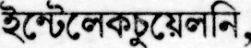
ইন্টেলেকচুয়েলনি,
